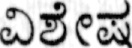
ವಿಶೇಷ
